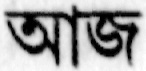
আজ
